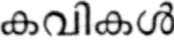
കവികള്‍
